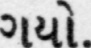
ગયો.
